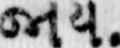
જાય.
